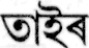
তাইৰ
